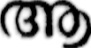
ആ
